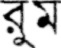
রুম
